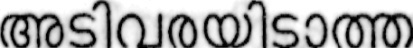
അടിവരയിടാത്ത
